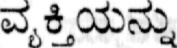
ವ್ಯಕ್ತಿಯನ್ನು
